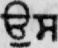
ਉਸ
